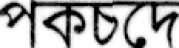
পকচদে
